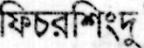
ফিচরশিংদু
